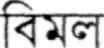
বিমল
